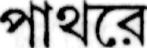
পাথরে
